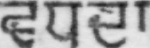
ਵਧਦਾ
